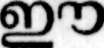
ഈ
